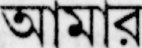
আমার
